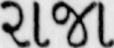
રાજા
